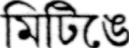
মিটিঙে
